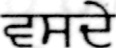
ਵਸਦੇ
